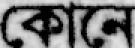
কোনে
